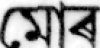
মোৰ
